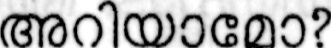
അറിയാമോ?
